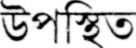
উপস্থিত
